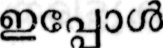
ഇപ്പോള്‍
